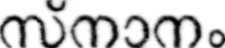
സ്നാനം
